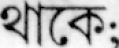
থাকে;
